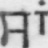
ਸਾਂ
